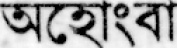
অহোংবা
